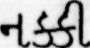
નક્કી
